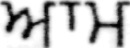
ਆਮ
